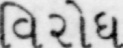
વિરોધ
